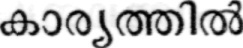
കാര്യത്തില്‍
